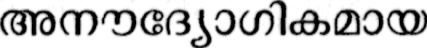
അനൌദ്യോഗികമായ
